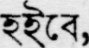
হইবে,
